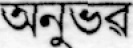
অনুভৱ
